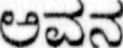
ಅವನ
